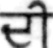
ਦੀ
